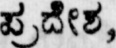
ಪ್ರದೇಶ,
